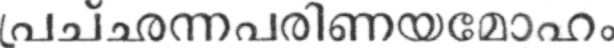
പ്രച്ഛന്നപരിണയമോഹം
